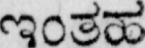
ಇಂತಹ
